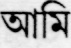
আমি
